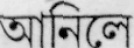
আনিলে
